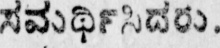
ಸಮರ್ಥಿಸಿದರು.
